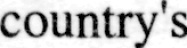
country's
